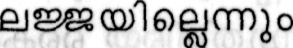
ലജ്ജയില്ലെന്നും
